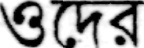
ওদের
